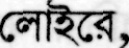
লোইরে,
